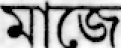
মাজে
